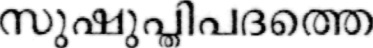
സുഷുപ്തിപദത്തെ
